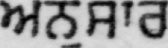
ਅਨੁਸਾਰ
